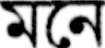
মনে
